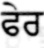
ਫੇਰ
